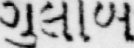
ગુલાબ
